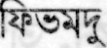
ফিভমদু
